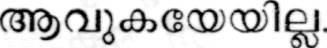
ആവുകയേയില്ല.
